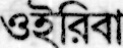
ওইরিবা
